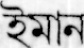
ইমান
